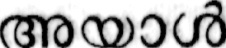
അയാള്‍
